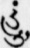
હું,
